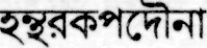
হন্থরকপদৌনা
